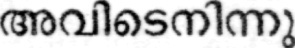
അവിടെനിന്നു
